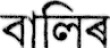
বালিৰ
